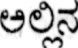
ಅಲ್ಲಿನ
